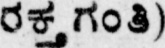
ರಕ್ತಗಂತಿ)
